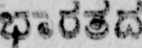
ಭಾರತದ
